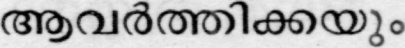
ആവര്‍ത്തിക്കയും
